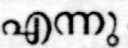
എന്നു
